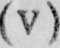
(v)
